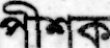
পীশক
